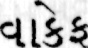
વાકેફ
